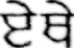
ਏਥੇ
